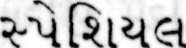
સ્પેશિયલ
